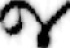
જ
